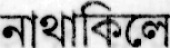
নাথাকিলে
